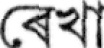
ৰেখা
